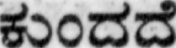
ಕುಂದದೆ
